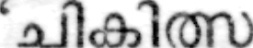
‘ചികിത്സ
